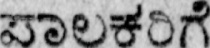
ಪಾಲಕರಿಗೆ
